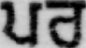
ਪਰ
